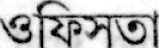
ওফিসতা
